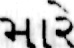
મારે
